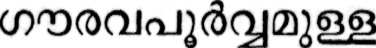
ഗൌരവപൂര്‍വ്വമുള്ള
